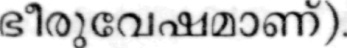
ഭീരുവേഷമാണ്).
